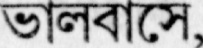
ভালবাসে,
